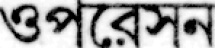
ওপরেসন
